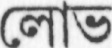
লোভ
